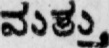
ಮತ್ತು
